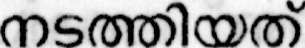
നടത്തിയത്
